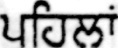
ਪਹਿਲਾਂ
